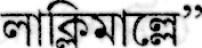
লাক্লিমাল্লে”
